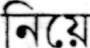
নিয়ে
